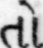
તો
